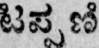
ಟಿಪ್ಪಣಿ
